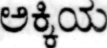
ಅಕ್ಕಿಯ
